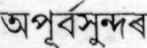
অপূর্বসুন্দৰ
